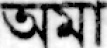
অমা
